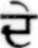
ਦੇ
